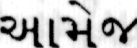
આમેજ
